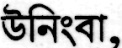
উনিংবা,
